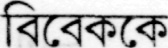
বিবেককে
